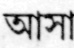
আসা
